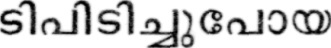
ടിപിടിച്ചുപോയ
